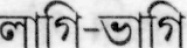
লাগি-ভাগি
